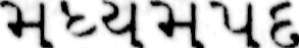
મધ્યમપદ
